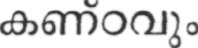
കണ്ഠവും
